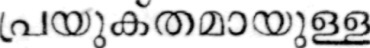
പ്രയുക്തമായുള്ള
